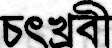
চৎখ্রবী
